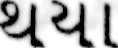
થયા
